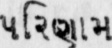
પરિણામ
